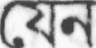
যেন
